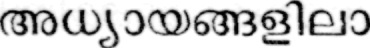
അധ്യായങ്ങളിലാ
